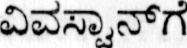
ವಿವಸ್ವಾನ್ ಗೆ
